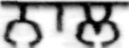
ਨਾਲ
